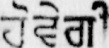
ਹੋਵੇਗੀ
